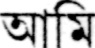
আমি
